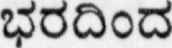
ಭರದಿಂದ
